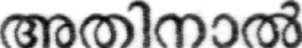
അതിനാല്‍
